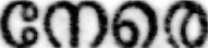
നേരെ
